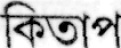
কিতাপ
